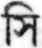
সি
